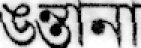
ঙন্তানা
